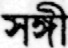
সঙ্গী
